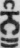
ਨੂੰ
